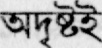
অদৃষ্টই
